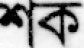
শক
